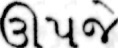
ઊપજે
